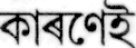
কাৰণেই
